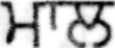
ਮਾਲ
